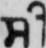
ਸੀ
